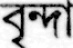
বৃন্দা
